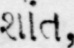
શાંત,
